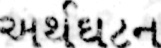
અર્થઘટન
